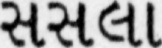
સસલા
